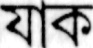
যাক
